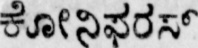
ಕೋನಿಫರಸ್
